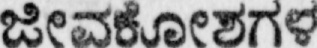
ಜೀವಕೋಶಗಳ
